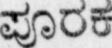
ಪೂರಕ
